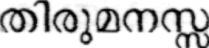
തിരുമനസ്സ
